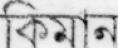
কিমান
